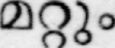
മറ്റും
